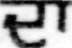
ਦਾ
